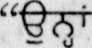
''ਉਨ੍ਹਾਂ
